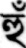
হুঁ
